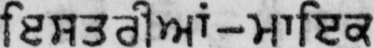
ਇਸਤਰੀਆਂ-ਮਾਇਕ
